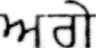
ਅਗੇ
